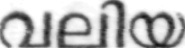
വലിയ
